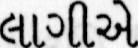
લાગીએ
